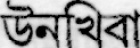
উনখিবা
